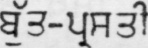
ਬੁੱਤ-ਪ੍ਰਸਤੀ
